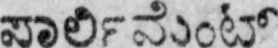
ಪಾರ್ಲಿಮೆಂಟ್
